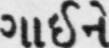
ગાઈને
